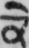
ਕੇ
